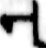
ન
